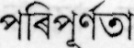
পৰিপূর্ণতা
